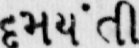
દમયંતી
